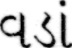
વડાં
